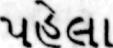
પહેલા
